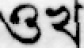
ওখ
